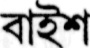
বাইশ
